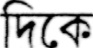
দিকে
